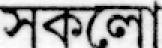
সকলো
